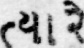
ત્યારે
